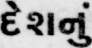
દેશનું
